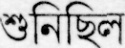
শুনিছিল
